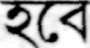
হবে
